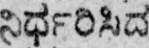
ನಿರ್ಧರಿಸಿದ
